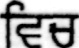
ਵਿਚ
